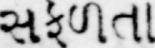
સફળતા
